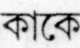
কাকে
